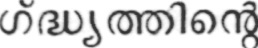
ഗ്ദ്ധ്യത്തിന്റെ
